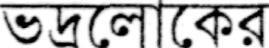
ভদ্রলোকের
